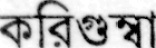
করিগুম্বা
